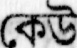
কেউ
